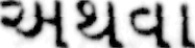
અથવા
